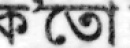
ক'তো
